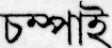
চম্পাই
